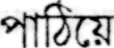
পাঠিয়ে
